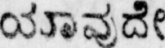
ಯಾವುದೇ
